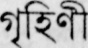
গৃহিণী
